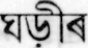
ঘড়ীৰ
